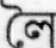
লৈ
